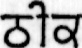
ਠੀਕ
